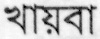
খায়বা
